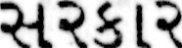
સરકાર
